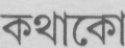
কথাকো
